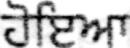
ਹੋਇਆ
